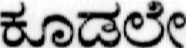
ಕೂಡಲೇ
